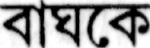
বাঘকে
